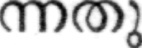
ന്നതു
